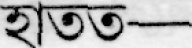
হাতত-
